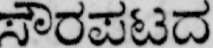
ಸೌರಪಟದ
